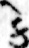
કે
